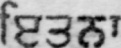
ਇਤਨਾ
